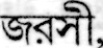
জরসী,
